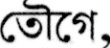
তৌগে,
